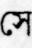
সে
